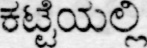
ಕಟ್ಟೆಯಲ್ಲಿ
